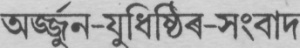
অৰ্জ্জুন-যুধিষ্ঠিৰ-সংবাদ
